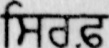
ਸਿਰਫ਼
